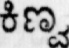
ಕಿಣ್ವ
